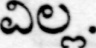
ವಿಲ್ಲ.
